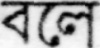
বলে
